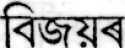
বিজয়ৰ
